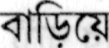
বাড়িয়ে
